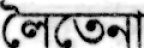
লৈতেনা
